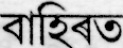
বাহিৰত
